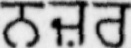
ਨਜ਼ਰ
